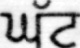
ਘੱਟ
